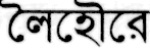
লৈহৌরে
